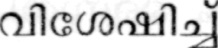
വിശേഷിച്ച്
